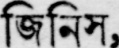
জিনিস,
